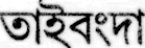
তাইবংদা
